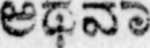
ಅಥವಾ
